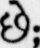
છે;
